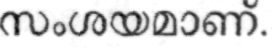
സംശയമാണ്.
